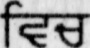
ਵਿਚ
